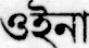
ওইনা
